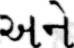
અને
